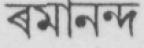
ৰমানন্দ
